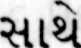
સાથે
